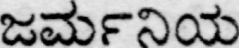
ಜರ್ಮನಿಯ
